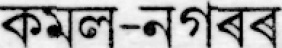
কমল-নগৰৰ
